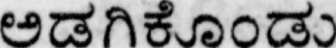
ಅಡಗಿಕೊಂಡು
